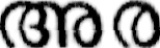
അര
